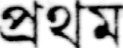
প্রথম
